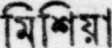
মিশিয়া
